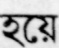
হয়ে
